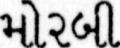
મોરબી
